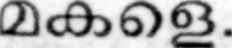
മകളെ.
